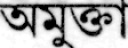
অমুক্তা
